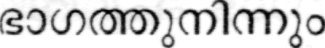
ഭാഗത്തുനിന്നും
